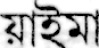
য়াইমা
